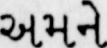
અમને
